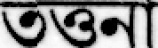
তত্তনা
